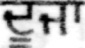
ਦੂਜਾ
